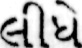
લીધે
